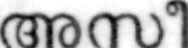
അസീ
